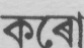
কৰো
